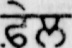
ਫ਼ੇਲ
